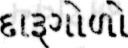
દારૂગોળો
